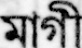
মাগী
